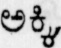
ಅಕ್ಕಿ,
